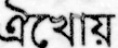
ঐখোয়
